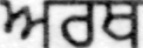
ਅਰਥ
